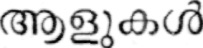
ആളുകള്‍
